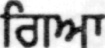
ਗਿਆ
